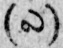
(ಎ)
